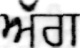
ਅੱਗ
